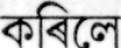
কৰিলে
